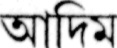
আদিম
